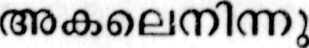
അകലെനിന്നു
